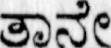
ತಾನೇ
